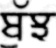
ਬੁੱਝ
